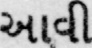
આવી
